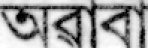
অৱাবা
